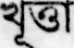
খূত্তা
